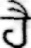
ਹੈ
